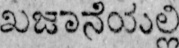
ಖಜಾನೆಯಲ್ಲಿ
